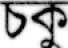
চকু
